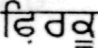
ਫ਼ਿਰਕੂ
